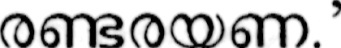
രണ്ടരയണ.'
